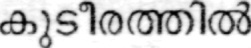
കുടീരത്തില്‍
